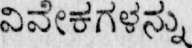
ವಿವೇಕಗಳನ್ನು
